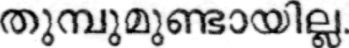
തുമ്പുമുണ്ടായില്ല.
